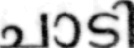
ചാടി
